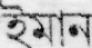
ইমান
